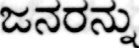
ಜನರನ್ನು
